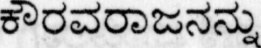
ಕೌರವರಾಜನನ್ನು
